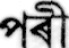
পৰী
